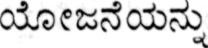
ಯೋಜನೆಯನ್ನು
